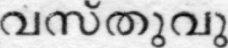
വസ്തുവു
